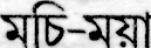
মচি-ময়া
